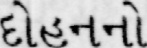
દોહનનો
